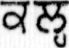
ਕਲ੍ਹ
